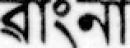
ৱাংনা
